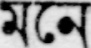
মনে
